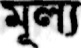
মূল্য
